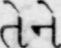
તેને
